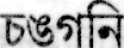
চঙগনি
